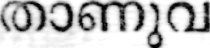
താണുവ
